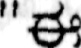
“ಈ
